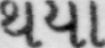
થયા
